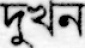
দুখন
